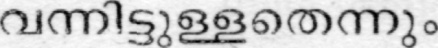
വന്നിട്ടുള്ളതെന്നും
